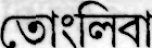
তোংলিবা
